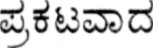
ಪ್ರಕಟವಾದ
